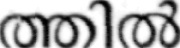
ത്തില്‍
